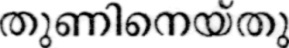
തുണിനെയ്തു
